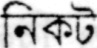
নিকট
